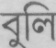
বুলি
